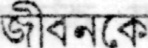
জীবনকে
